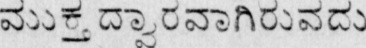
ಮುಕ್ತದ್ವಾರವಾಗಿರುವದು
